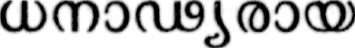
ധനാഢ്യരായ
